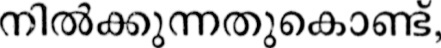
നില്‍ക്കുന്നതുകൊണ്ട്,
